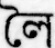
লৈ
